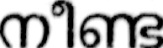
നീണ്ട
